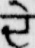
ਦੇ
